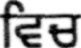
ਵਿਚ
